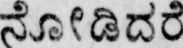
ನೋಡಿದರೆ
